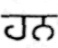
ਹਨ
